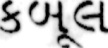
કબૂલ
